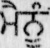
ਮੈਨੂੰ
